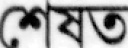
শেষত
